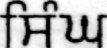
ਸਿੰਘ
